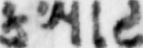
કબાટ
